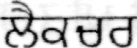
ਲੈਕਚਰ
